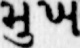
મુખ
